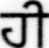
ਹੀ
